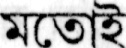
মতোই
